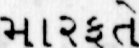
મારફતે
